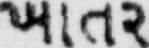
ખાતર
